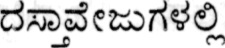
ದಸ್ತಾವೇಜುಗಳಲ್ಲಿ
